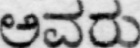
ಅವರು
